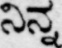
ನಿನ್ನ
